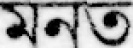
মনত
